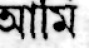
আমি
